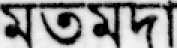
মতমদা
